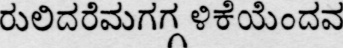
ರುಲಿದರೆಮಗಗ್ಗಳಿಕೆಯೆಂದವ
